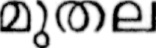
മുതല
